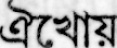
ঐখোয়
